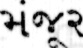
મંજૂર
